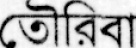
তৌরিবা
